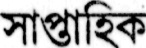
সাপ্তাহিক
